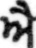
ਐ
